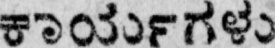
ಕಾರ್ಯಗಳು
